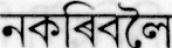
নকৰিবলৈ
